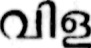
വിള
